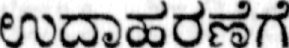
ಉದಾಹರಣೆಗೆ
